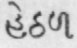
હેઠળ
